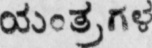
ಯಂತ್ರಗಳ
